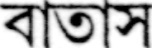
বাতাস
